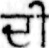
ਦੀ
